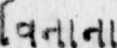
વિનાના
